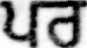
ਪਰ
